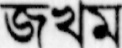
জখম
